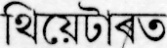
থিয়েটাৰত
